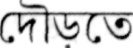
দৌড়তে
